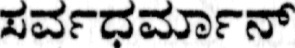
ಸರ್ವಧರ್ಮಾನ್
